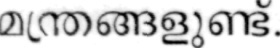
മന്ത്രങ്ങളുണ്ട്.
